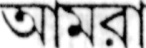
আমরা
